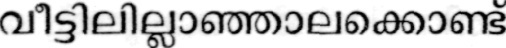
വീട്ടിലില്ലാഞ്ഞാലക്കൊണ്ട്
